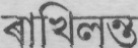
ৰাখিলন্ত
